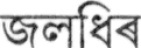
জলধিৰ
